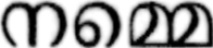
നമ്മെ
